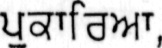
ਪੁਕਾਰਿਆ,
